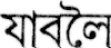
যাবলৈ
